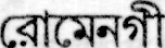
রোমেনগী
